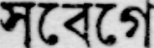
সবেগে
